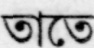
তাতে
